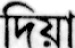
দিয়া
